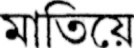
মাতিয়ে
